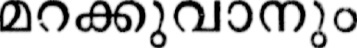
മറക്കുവാനും
